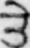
ਤੇ
